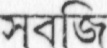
সবজি
